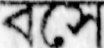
বসে
